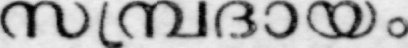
സമ്പ്രദായം
